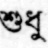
শুধু
